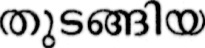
തുടങ്ങിയ
